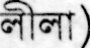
লীলা)
